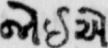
જોઈએ
